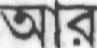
আর
